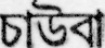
চাউবা
